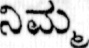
ನಿಮ್ಮ
